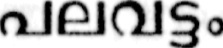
പലവട്ടം
